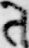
તે
